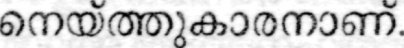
നെയ്ത്തുകാരനാണ്.
